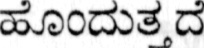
ಹೊಂದುತ್ತದೆ
